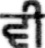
ਵੀ
